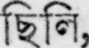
ছিলি,
